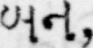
બન,
